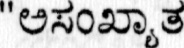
“ಅಸಂಖ್ಯಾತ
